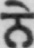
ਨੇ
